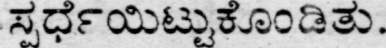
ಸ್ಪರ್ಧೆಯಿಟ್ಟುಕೊಂಡಿತು.
